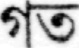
গত
